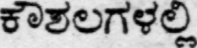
ಕೌಶಲಗಳಲ್ಲಿ
